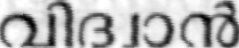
വിദ്വാന്‍
